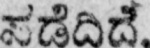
ಪಡೆದಿದೆ.
